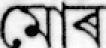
মোৰ
